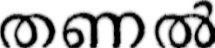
തണല്‍
